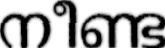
നീണ്ട
